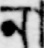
না
